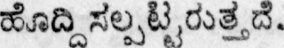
ಹೊದ್ದಿಸಲ್ಪಟ್ಟಿರುತ್ತದೆ.
